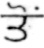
ਤੋਂ
